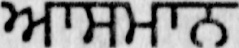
ਆਸਮਾਨ
